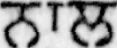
ਨਾਲ
